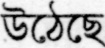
উঠেছে
